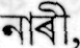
নাৰী,
